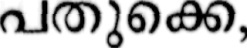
പതുക്കെ,
